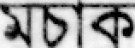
মচাক
